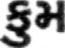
કુમ
